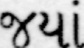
જ્યાં
